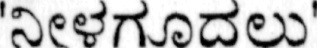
ನೀಳಗೂದಲು’
